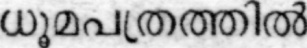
ധൂമപത്രത്തില്‍
